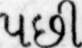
પછી
